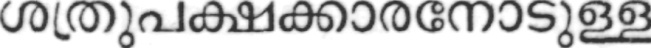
ശത്രുപക്ഷക്കാരനോടുള്ള
